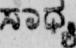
ಸಾಧ್ಯ
